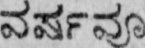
ವರ್ಷವೂ
